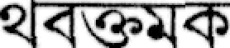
থবক্তমক
